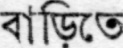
বাড়িতে
